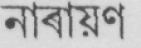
নাৰায়ণ
